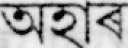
অহাৰ
